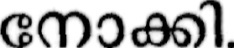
നോക്കി.
